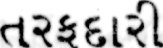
તરફદારી
